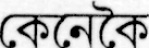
কেনেকৈ
